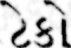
ટેકો
